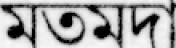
মতমদা
